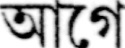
আগে
